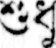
শুধু
